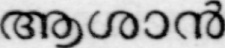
ആശാന്‍
